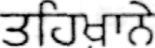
ਤਹਿਖ਼ਾਨੇ
